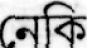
নেকি
